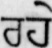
ਰਹੇ
